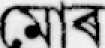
মোৰ
